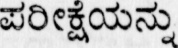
ಪರೀಕ್ಷೆಯನ್ನು
